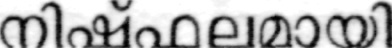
നിഷ്ഫലമായി
